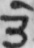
ਤੇ
